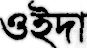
ওইদা
